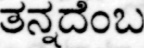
ತನ್ನದೆಂಬ
